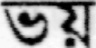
ভয়
